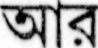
আর
